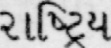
રાષ્ટ્રીય
